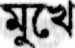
মুখে
